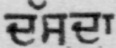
ਦੱਸਦਾ
